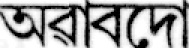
অৱাবদো
